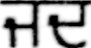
ਜਦ
